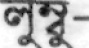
লুম্বু-
